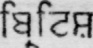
ਬ੍ਰਿਟਿਸ਼
